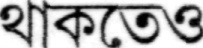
থাকতেও
